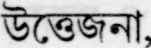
উত্তেজনা,
